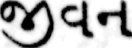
જીવન
